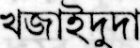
খজাইদুদা
